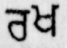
ਰਖ
